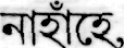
নাহাঁহে,
